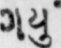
ગયું
